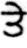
ਤੇ
